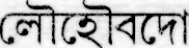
লৌহৌবদো
